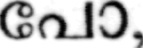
പോ,
